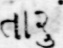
તારું
